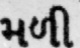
મળી
